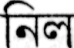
নিল
